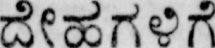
ದೇಹಗಳಿಗೆ
